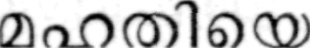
മഹതിയെ
